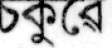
চকুৱে
